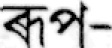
ৰূপ-
